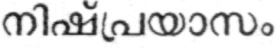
നിഷ്പ്രയാസം
